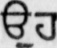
ਉਹ
